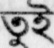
তুই
